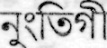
নুংতিগী
